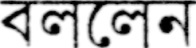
বললেন
